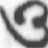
ও
